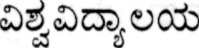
ವಿಶ್ವವಿದ್ಯಾಲಯ
